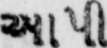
આપી
